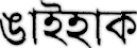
ঙাইহাক
